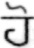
ਹੋ
